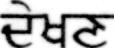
ਦੇਖਣ
